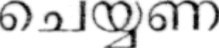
ചെയ്യണ
